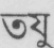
তযু
